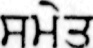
ਸਮੇਤ
